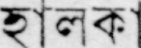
হালকা
